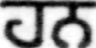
ਹਨ
